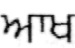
ਆਖ
